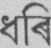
ধৰি
